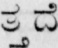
ತ್ತದೆ
